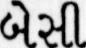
બેસી
